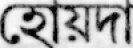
হোয়দা
